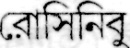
রোসিনিবু
